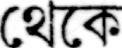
থেকে
